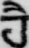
ਹੈ
